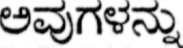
ಅವುಗಳನ್ನು
